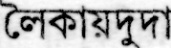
লৈকায়দুনা
